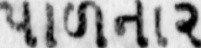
પાળનાર
